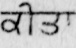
ਕੀਤਾ
